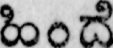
ಹಿಂದೆ
